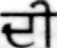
ਦੀ
